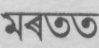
মৰতত
